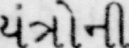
યંત્રોની
